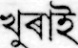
খুৰাই
